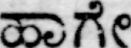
ಹಾಗೇ
